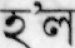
হ'ল
